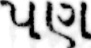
પણ
